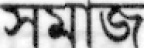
সমাজ
